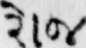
રોજ
